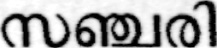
സഞ്ചരി
